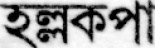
হল্লকপা
